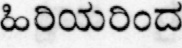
ಹಿರಿಯರಿಂದ
